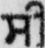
ਸੀ
